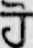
ਹੋ
